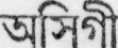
অসিগী
